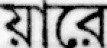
য়ারে
